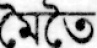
মৈতৈ
